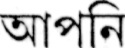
আপনি
